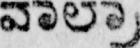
ವಾಲ್ರಾ
